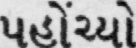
પહોંચ્યો
